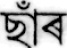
ছাঁৰ
